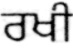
ਰਖੀ
